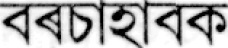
বৰচাহাবক
